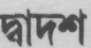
দ্বাদশ
